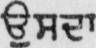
ਉਸਦਾ
